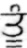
ਤੂੰ
